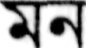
মন
